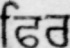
ਫਿਰ
